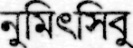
নুমিৎসিবু
